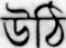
উঠি
